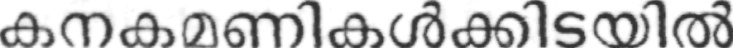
കനകമണികള്‍ക്കിടയില്‍
